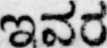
ಇವರ
